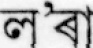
ল'ৰা
